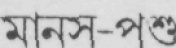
মানস-পশু
